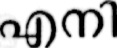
എനി
